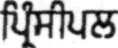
ਪ੍ਰਿੰਸੀਪਲ
